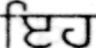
ਇਹ
